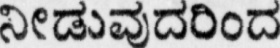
ನೀಡುವುದರಿಂದ
